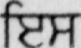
ਇਸ
